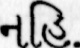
નહિ.
